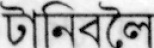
টানিবলৈ
